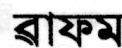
ৱাফম
